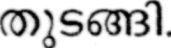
തുടങ്ങി.
